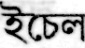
ইচেল
